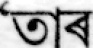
'তাৰ
